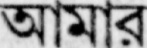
আমার
